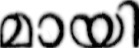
മായി
